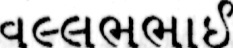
વલ્લભભાઈ
